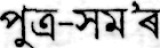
পুত্র-সম'ৰ
